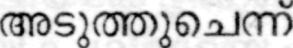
അടുത്തുചെന്ന്
